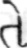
તે
